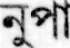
নুপা
